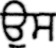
ਉਸ
